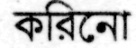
করিনো
